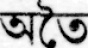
অতৈ
